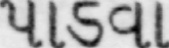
પાડવા
